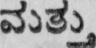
ಮತ್ತು
